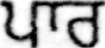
ਪਾਰ
